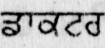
ਡਾਕਟਰ
